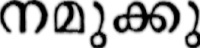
നമുക്കു
